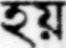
হয়
